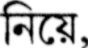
নিয়ে,
